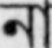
না
